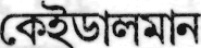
কেইডালমান
